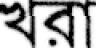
খরা
